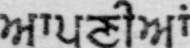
ਆਪਣੀਆਂ
